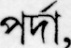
পর্দা,
